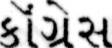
કૉંગ્રેસ
